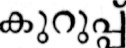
കുറുപ്പ്
